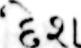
દેશ
